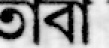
তাবা
